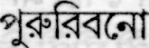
পুরুরিবনো
